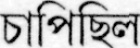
চাপিছিল
